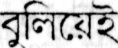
বুলিয়েই
